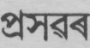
প্ৰসৱৰ
